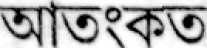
আতংকত
